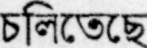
চলিতেছে
